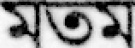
মতম
